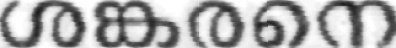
ശങ്കരനെ
